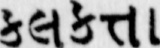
કલકત્તા
